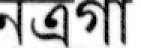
নত্রগা
